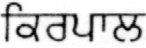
ਕਿਰਪਾਲ
